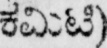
ಕಮಿಟಿ)
